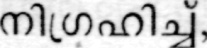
നിഗ്രഹിച്ച്,
